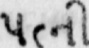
પત્ની
